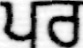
ਪਰ
